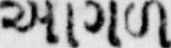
આગળ
